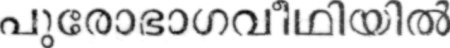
പുരോഭാഗവീഥിയില്‍
